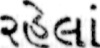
રહેલાં
